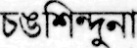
চঙশিন্দুনা
